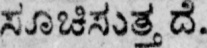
ಸೂಚಿಸುತ್ತದೆ.
